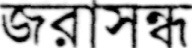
জরাসন্ধ
